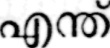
എന്ത്
